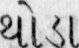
થોડા
